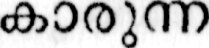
കാരുന്ന
